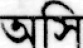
অসি
